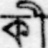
কী
